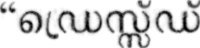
“ഡ്രെസ്സ്ഡ്
